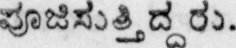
ಪೂಜಿಸುತ್ತಿದ್ದರು.
